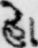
હો
